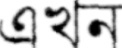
এখন
